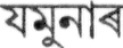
যমুনাৰ
